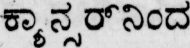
ಕ್ಯಾನ್ಸರ್‌ನಿಂದ
